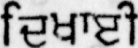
ਦਿਖਾਈ
